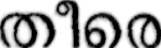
തീരെ
